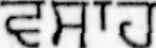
ਵਸਾਹ
